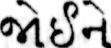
જોઈને
